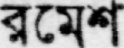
রমেশ
